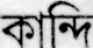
কান্দি
